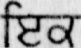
ਇਕ
